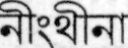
নীংথীনা
